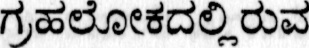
ಗ್ರಹಲೋಕದಲ್ಲಿರುವ
